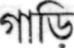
গাড়ি
